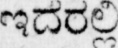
ಇದರಲ್ಲಿ
